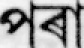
পৰা
